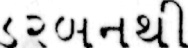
ડરબનથી
